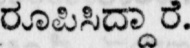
ರೂಪಿಸಿದ್ದಾರೆ.
